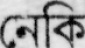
নেকি
